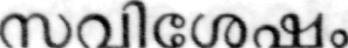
സവിശേഷം
